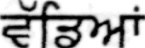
ਵੱਡਿਆਂ
